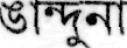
ঙান্দুনা
